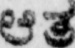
ಆತ
